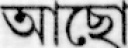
আছো
